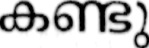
കണ്ടു
